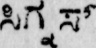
ಸಿಗ್ನಸ್
